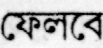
ফেলবে
